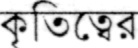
কৃতিত্বের
